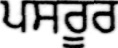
ਪਸਰੂਰ
